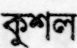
কুশল
